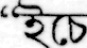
“ইচে
